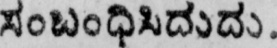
ಸಂಬಂಧಿಸಿದುದು.
